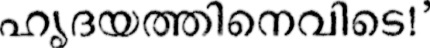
ഹൃദയത്തിനെവിടെ!’
